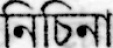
নিচিনা
